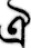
ঐ
